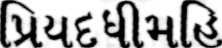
પ્રિયદધીમહિ
